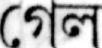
গেল
